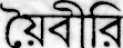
য়ৈবীরি
